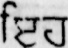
ਇਹ
